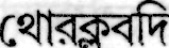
থোরক্লবদি
